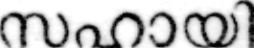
സഹായി
